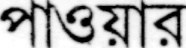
পাওয়ার
